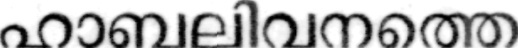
ഹാബലിവനത്തെ
